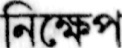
নিক্ষেপ
